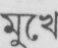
মুখে
